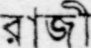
রাজী
